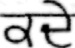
ਕਦੇ
